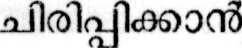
ചിരിപ്പിക്കാന്‍
